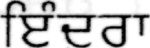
ਇੰਦਰਾ
